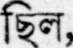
ছিল,
